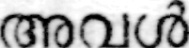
അവള്‍
